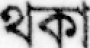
থকা
